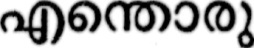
എന്തൊരു
